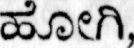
ಹೋಗಿ,
